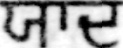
ਯਾਦ
